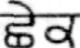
ਛੇਕ
